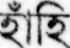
হাঁহি
